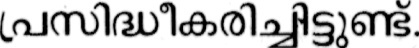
പ്രസിദ്ധീകരിച്ചിട്ടുണ്ട്.
